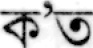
ক'ত
